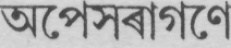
অপেসৰাগণে
